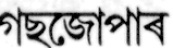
গছজোপাৰ
